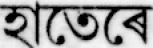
হাতেৰে
